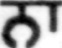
ਨਾ
